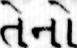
તેનો
